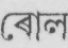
ৰোল
